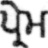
ਪ੍ਰੇਮ
